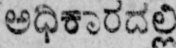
ಅಧಿಕಾರದಲ್ಲಿ
